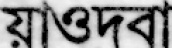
য়াওদবা
